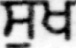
ਸੁਖ
